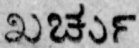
ಖರ್ಚು
